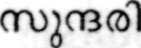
സുന്ദരി
